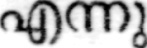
എന്നു
